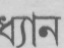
ধ্যান
